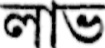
লাভ
